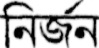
নির্জন
